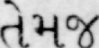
તેમજ
